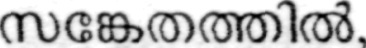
സങ്കേതത്തില്‍,
